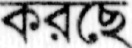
করছে
